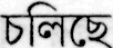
চলিছে
